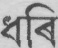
ধৰি
